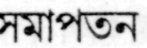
সমাপতন
